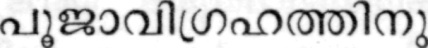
പൂജാവിഗ്രഹത്തിനു
